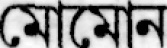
মোমোন
